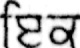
ਇਕ
